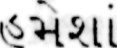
હમેશાં
